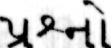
પ્રશ્નો
